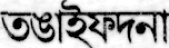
তঙাইফদনা
